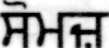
ਸੋਮਜ਼
